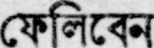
ফেলিবেন
